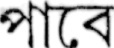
পাবে
